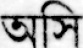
অসি
